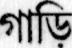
গাড়ি
